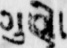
ગુણો
